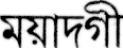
ময়াদগী
